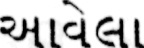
આવેલા
